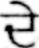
ਦੇ
